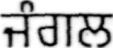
ਜੰਗਲ
